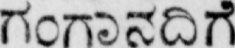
ಗಂಗಾನದಿಗೆ
